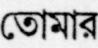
তোমার
